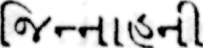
જિન્નાહની
